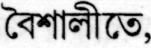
বৈশালীতে,
